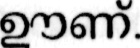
ഊണ്.
